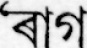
'ৰাগ
